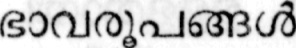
ഭാവരൂപങ്ങള്‍
